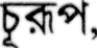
চূরূপ,
